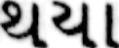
થયા
